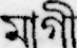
মাগী
